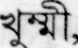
খুম্মী,
